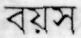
বয়স
